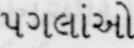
પગલાંઓ
